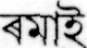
ৰমাই
